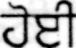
ਹੋਈ
